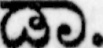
ಡಾ.
